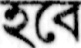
হবে
